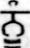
ਨੂੰ
